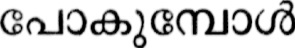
പോകുമ്പോള്‍
